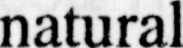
natural
